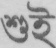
শুই
